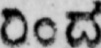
ರಿಂದ
